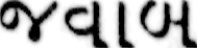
જવાબ
